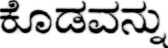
ಕೊಡವನ್ನು
